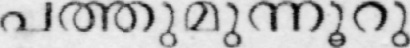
പത്തുമുന്നൂറു
